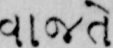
વાજતે
